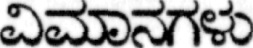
ವಿಮಾನಗಳು
